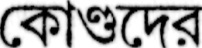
কোণ্ডদের
